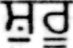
ਸ਼ੁਰੂ
